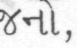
જનો,
